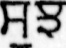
ਸੁਝ
